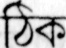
ঠিক
